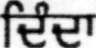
ਦਿੰਦਾ
